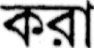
করা
